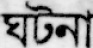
ঘটনা
